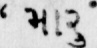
'મારું
